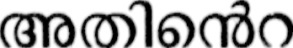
അതിന്റെ
